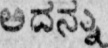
ಅದನ್ನು
